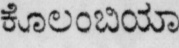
ಕೊಲಂಬಿಯಾ
